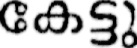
കേട്ടു
